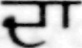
ਦਾ
